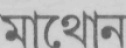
মাথোন
